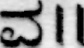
ವ||
